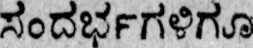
ಸಂದರ್ಭಗಳಿಗೂ
